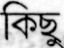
কিছু
